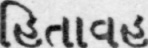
હિતાવહ
